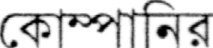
কোম্পানির
